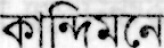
কান্দিমনে
